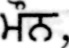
ਮੌਨ,
